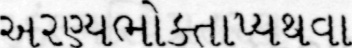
અરણ્યભોક્તાપ્યથવા
